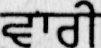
ਵਾਰੀ
